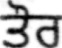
ਤੌਰ
